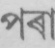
পৰা
